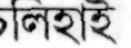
চলিহাই
